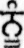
ਨੂੰ
